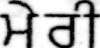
ਮੇਰੀ
